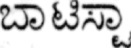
ಬಾಟಿಸ್ಟಾ
